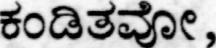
ಕಂಡಿತವೋ,
